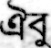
ঐবু
